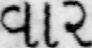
વાર
